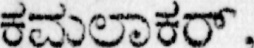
ಕಮಲಾಕರ್,
